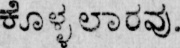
ಕೊಳ್ಳಲಾರವು.
